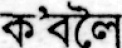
ক'বলৈ
